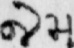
જેમ
